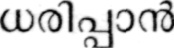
ധരിപ്പാന്‍
